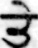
ਤੇ
